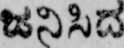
ಜನಿಸಿದ
